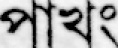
পাখং
